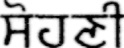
ਸੋਹਣੀ
